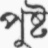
পুষ্ট
